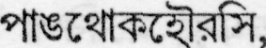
পাঙথোকহৌরসি,
